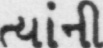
ત્યાંની
